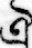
ঐ
